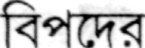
বিপদের
